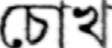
চোখ
